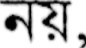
নয়,
